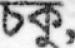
চকু,
